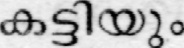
കട്ടിയും
